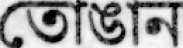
তোঙান
